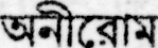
অনীরোম
